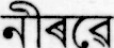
নীৰৱে
